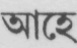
আহে
